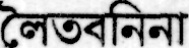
লৈতবনিনা
